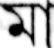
মা
